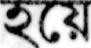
হয়ে
